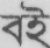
বই
